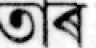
তাৰ
